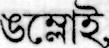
ঙম্লোই,
